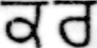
ਕਰ
